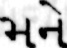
મને
